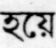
হয়ে
